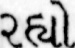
રહ્યો
